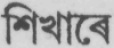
শিখাৰে
